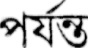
পর্যন্ত
